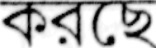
করছে
